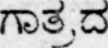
ಗಾತ್ರದ
